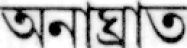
অনাঘ্ৰাত
